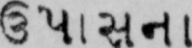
ઉપાસના
